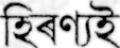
হিৰণ্যই
